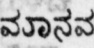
ಮಾನವ
